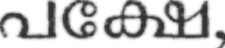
പക്ഷേ,
